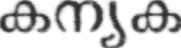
കന്യക
